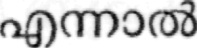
എന്നാല്‍
